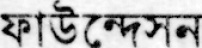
ফাউন্দেসন
